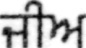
ਜੀਅ
